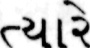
ત્યારે
